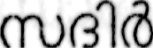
സദിര്‍
